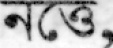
নত্তে,
